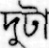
দুটা
